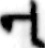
ન
